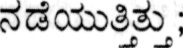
ನಡೆಯುತ್ತಿತ್ತು;
